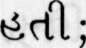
હતી;
